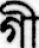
গী
